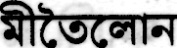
মীতৈলোন
